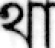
থা
